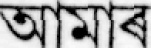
আমাৰ
